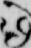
છે
